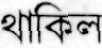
থাকিল
